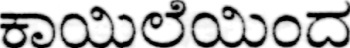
ಕಾಯಿಲೆಯಿಂದ
